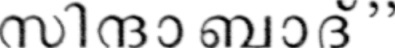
സിന്ദാബാദ്"
